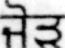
ਜੋੜ
